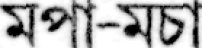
মপা-মচা
